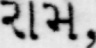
રામ,
